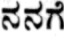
ನನಗೆ
